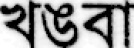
খঙবা
